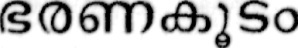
ഭരണകൂടം
